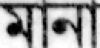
মানা
